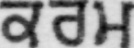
ਕਰਮ
